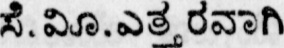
ಸೆ.ಮೀ.ಎತ್ತರವಾಗಿ
